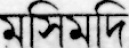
মসিমদি
